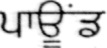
ਪਾਊਂਡ
